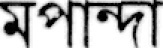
মপান্দা
